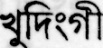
খুদিংগী
